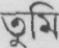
তুমি
